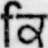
ਕਿ
